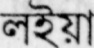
লইয়া
